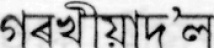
গৰখীয়াদ'ল
